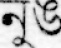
নুঙ
